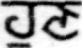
ਹੁਣ
